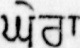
ਘੇਰਾ
